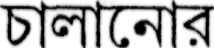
চালানোর
